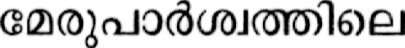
മേരുപാര്‍ശ്വത്തിലെ
